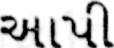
આપી
